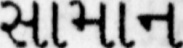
સામાન
